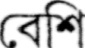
বেশি
